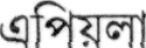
এপিয়লা
